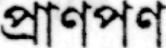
প্রাণপণ
